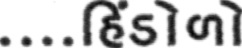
હિંડોળો
